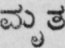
ಮೃತ
